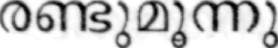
രണ്ടുമൂന്നു
